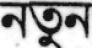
নতুন
